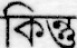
কিন্তু
